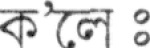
ক'লেঃ
